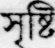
সৃষ্টি
